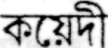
কয়েদী
